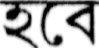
হবে
